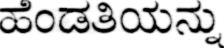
ಹೆಂಡತಿಯನ್ನು
